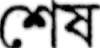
শেষ
